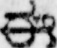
ಈ
